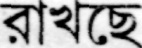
রাখছে
